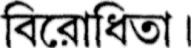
বিরোধিতা।
